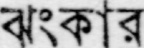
ঝংকার
